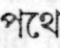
পথে
